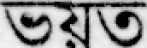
ভয়ত
